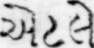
એટલે
